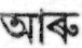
আৰু
